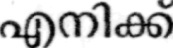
എനിക്ക്
